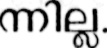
ന്നില്ല.
